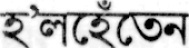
হ'লহেঁতেন
